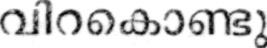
വിറകൊണ്ടു
